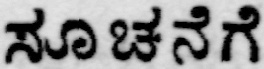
ಸೂಚನೆಗೆ
